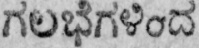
ಗಲಭೆಗಳಿಂದ
